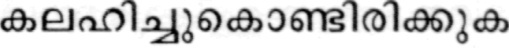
കലഹിച്ചുകൊണ്ടിരിക്കുക
